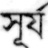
সূর্য
